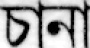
চানা
